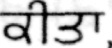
ਕੀਤਾ,
